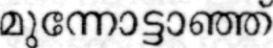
മുന്നോട്ടാഞ്ഞ്
